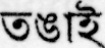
তঙাই
